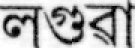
লগুৱা
